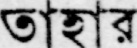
তাহার
